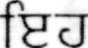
ਇਹ
